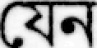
যেন
